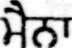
ਮੈਨਾ
